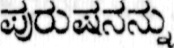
ಪುರುಷನನ್ನು
